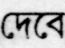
দেবে
